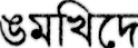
ঙমখিদে
